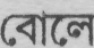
বোলে
